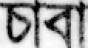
চাবা
